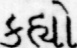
કહ્યો
